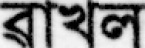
ৱাখল
